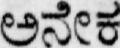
ಅನೇಕ
